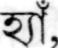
হ্যাঁ,
